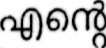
എന്റെ
